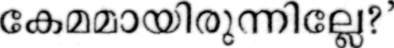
കേമമായിരുന്നില്ലേ?'
